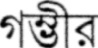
গম্ভীর
